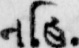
નહિ.
